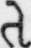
તે
